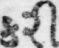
કરી
